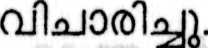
വിചാരിച്ചു.
